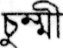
চুম্মী
